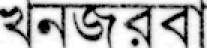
খনজরবা
